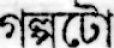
গল্পটো
